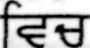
ਵਿਚ
